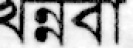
খন্নবা
